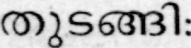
തുടങ്ങി:
